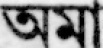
অমা
